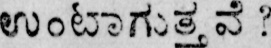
ಉಂಟಾಗುತ್ತವೆ?
